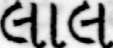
લાલ
